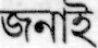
জনাই
